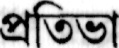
প্রতিভা
